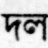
দল
